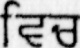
ਵਿਚ
